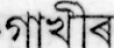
গাখীৰ
